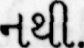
નથી.
